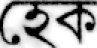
হেক
